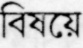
বিষয়ে
